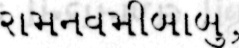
રામનવમીબાબુ,
